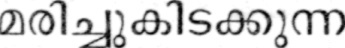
മരിച്ചുകിടക്കുന്ന
